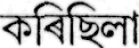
কৰিছিলা
